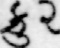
ક્રુર
